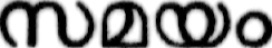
സമയം
